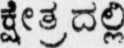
ಕ್ಷೇತ್ರದಲ್ಲಿ
